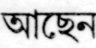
আছেন
